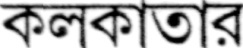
কলকাতার
